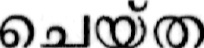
ചെയ്ത
